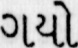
ગયો
